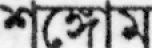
শঙ্গোম
